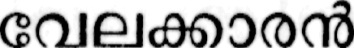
വേലക്കാരന്‍
